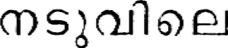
നടുവിലെ
